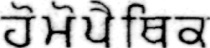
ਹੋਮੋਪੈਥਿਕ
